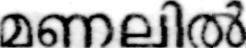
മണലില്‍
